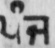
ਪੰਜ
